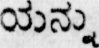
ಯನ್ನು
